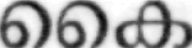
കൈ
